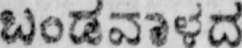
ಬಂಡವಾಳದ
